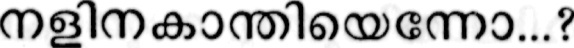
നളിനകാന്തിയെന്നോ...?
